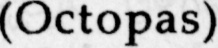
(Octopas)
